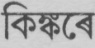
কিঙ্কৰে
